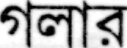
গলার
